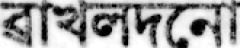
ৱাখলনো
